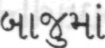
બાજુમાં
